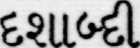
દશાબ્દી
